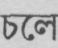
চলে
